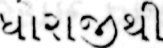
ધોરાજીથી
